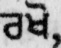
ਰਖੋ,
